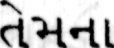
તેમના
